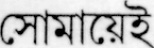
সোমায়েই
